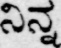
ನಿನ್ನ
